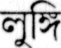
লুঙ্গি
